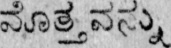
ಮೊತ್ತವನ್ನು
